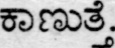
ಕಾಣುತ್ತೆ.
